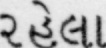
રહેલા
